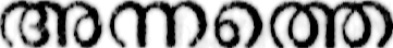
അന്നത്തെ
